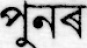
পুনৰ
